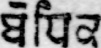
ਬੋਧਿਕ
